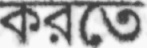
করতে
